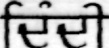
ਦਿੰਦੀ
